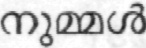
നുമ്മള്‍
